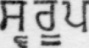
ਸ੍ਵਰੂਪ
